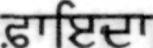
ਫ਼ਾਇਦਾ
